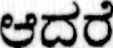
ಆದರೆ
